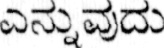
ಎನ್ನುವುದು
